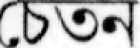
চেতন
